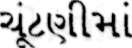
ચૂંટણીમાં
